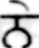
ਨੇ
